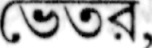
ভেতর,
